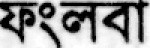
ফংলবা
